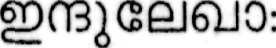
ഇന്ദുലേഖാ:
